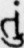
તું
